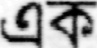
এক
